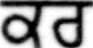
ਕਰ
